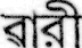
ৱারী
